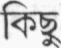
কিছু
